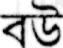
বউ
